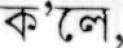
ক'লে,
